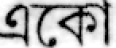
একো
